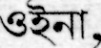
ওইনা,
